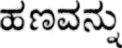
ಹಣವನ್ನು
